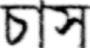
চাস
